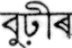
বুঢ়ীৰ
